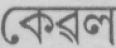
কেৱল
